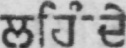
ਲਹਿੰਦੇ
